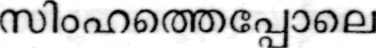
സിംഹത്തെപ്പോലെ
